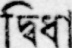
দ্বিধা
